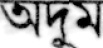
অদুম
